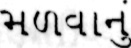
મળવાનું
